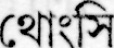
থোংসি
